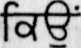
ਕਿਉਂ
